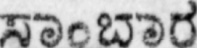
ಸಾಂಬಾರ
